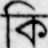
কি
